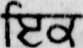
ਇਕ
